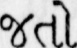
જતો
